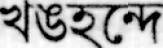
খঙহন্দে
